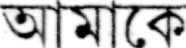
আমাকে
